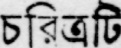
চরিত্রটি
